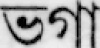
ভগা
